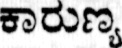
ಕಾರುಣ್ಯ
